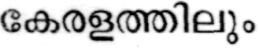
കേരളത്തിലും
